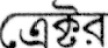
ত্রেক্টর
